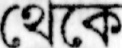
থেকে
